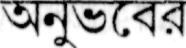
অনুভবের
